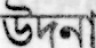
উদনা
